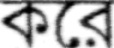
করে
